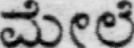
ಮೇಲೆ
